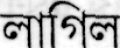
লাগিল
